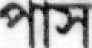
পাস
